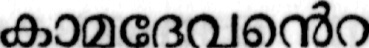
കാമദേവന്റെ
